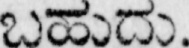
ಬಹುದು.
